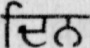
ਦਿਨ
